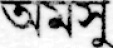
অমসু
